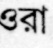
ওরা
